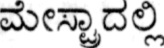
ಮೇಸ್ಟ್ರಾದಲ್ಲಿ
